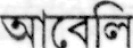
আবেলি
